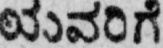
ಯವರಿಗೆ
